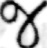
જ
